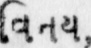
વિનય,
